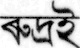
ৰুদ্ৰই
